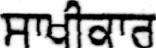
ਸਾਖੀਕਾਰ
